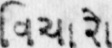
વિચારો
